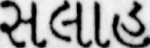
સલાહ
